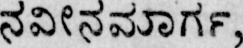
ನವೀನಮಾರ್ಗ,
